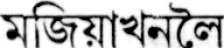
মজিয়াখনলৈ
